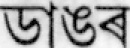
ডাঙৰ
